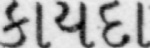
કાયદા
